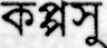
কপ্পসু
